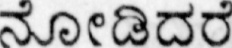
ನೋಡಿದರೆ
